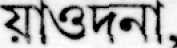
য়াওদনা,
